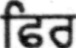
ਫਿਰ
